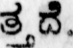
ತ್ತದೆ.
